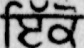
ਇੱਕੋ
